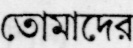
তোমাদের
